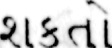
શકતો
